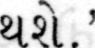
થશે.'
